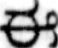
ಈ
